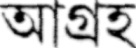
আগ্রহ
